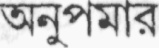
অনুপমার
